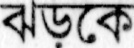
ঝড়কে
